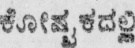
ಕೋಷ್ಟಕದಲ್ಲಿ
